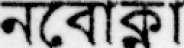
নবোক্না
